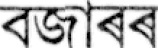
বজাৰৰ
